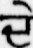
ਦੇ
